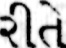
રીતે
